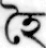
হৈ
